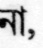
না,
